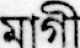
মাগী
